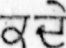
ਕਦੇ
